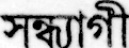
সন্ধ্যাগী
